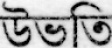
উভতি
